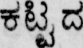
ಕಟ್ಟಿದ
